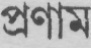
প্ৰণাম
